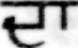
ਦਾ
